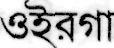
ওইরগা
